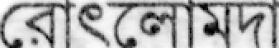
রোৎলোমদা
